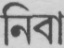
নিবা
